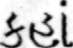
કહાં
